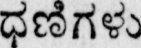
ಧಣಿಗಳು
